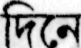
দিনে
